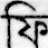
ফি
